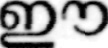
ഈ
